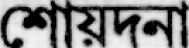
শোয়দনা
